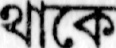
থাকে
